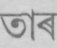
তাৰ
